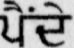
ਪੈਂਦੇ
